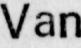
Van
